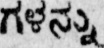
ಗಳನ್ನು
